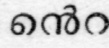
ന്റെ
